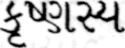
કૃષ્ણસ્ય
